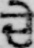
ਦੇ
